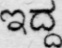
ಇದ್ದ
